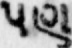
પણ
